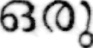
ഒരു
